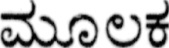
ಮೂಲಕ
